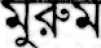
মুরুম
